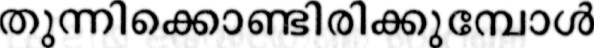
തുന്നിക്കൊണ്ടിരിക്കുമ്പോള്‍
